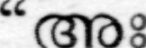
"അഃ
